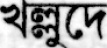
খল্লুদে
